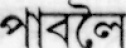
পাবলৈ
